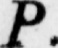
P.
